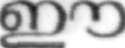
ഈ
